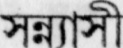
সন্ন্যাসী
